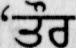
'ਤੌਰ
